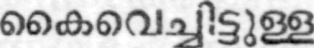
കൈവെച്ചിട്ടുള്ള
